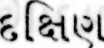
દક્ષિણ
